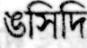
ঙসিদি
